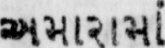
અમારામાં
